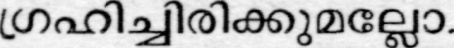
ഗ്രഹിച്ചിരിക്കുമല്ലോ.
